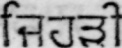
ਜਿਹੜੀ
